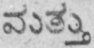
ಮತ್ತು
